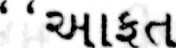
"આફત
